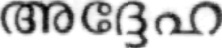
അദ്ദേഹ
